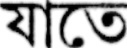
যাতে
